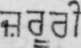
ਜ਼ਰੂਰੀ
